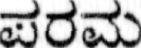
ಪರಮ
